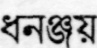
ধনঞ্জয়
